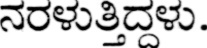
ನರಳುತ್ತಿದ್ದಳು.
